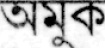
অমুক
